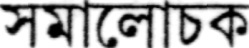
সমালোচক
